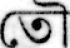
তৌ
